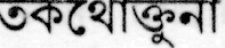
তকথোক্তুনা
